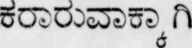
ಕರಾರುವಾಕ್ಕಾಗಿ
